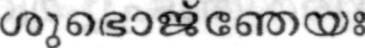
ശുഭൊജ്ഞേയഃ
